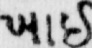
ખાઈ
